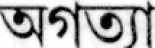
অগত্যা
